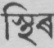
স্থিৰ
